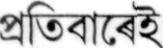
প্রতিবাৰেই
